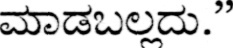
ಮಾಡಬಲ್ಲದು."
